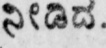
ನೀಡಿದ.
